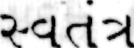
સ્વતંત્ર
